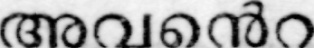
അവന്റെ
